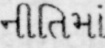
નીતિમાં
